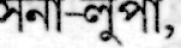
সনা-লুপা,
